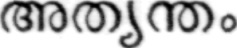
അത്യന്തം
